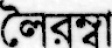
লৈরম্বা
